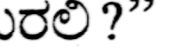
ಬರಲಿ?"
